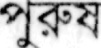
পুরুষ
